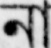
না
